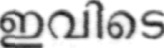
ഇവിടെ
